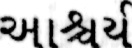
આશ્ચર્ય
